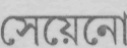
সেয়েনো
